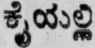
ಕೈಯಲ್ಲಿ
